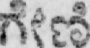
ಗೇಣಿ
